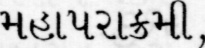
મહાપરાક્રમી,
